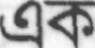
এক
